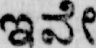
ಇವೇ
